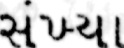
સંખ્યા
